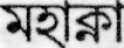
মহাক্না
